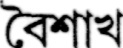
বৈশাখ
